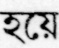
হয়ে
